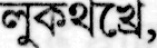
লুকথখ্রে,
